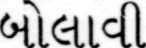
બોલાવી
